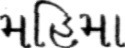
મહિમા
